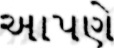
આપણે
